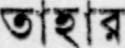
তাহার
